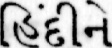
હિંદીને
